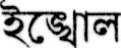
ইঙ্খোল
